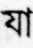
যা
